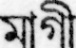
মাগী
